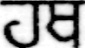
ਹਥ
